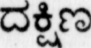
ದಕ್ಷಿಣ
